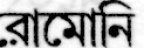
রোমোনি
